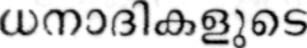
ധനാദികളുടെ
